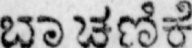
ಬಾಚಣಿಕೆ
